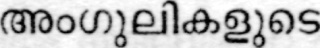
അംഗുലികളുടെ
